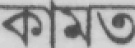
কামত
